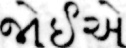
જોઈએ
